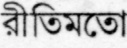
রীতিমতো
